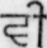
ਵੀ
